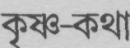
কৃষ্ণ-কথা
